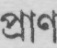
প্ৰাণ
